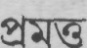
প্ৰমত্ত
